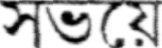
সভয়ে
